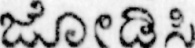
ಜೋಡಿಸಿ
